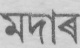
মদাৰ
